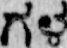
ಗಳ
